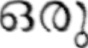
ഒരു
